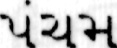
પંચમ
